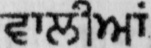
ਵਾਲੀਆਂ
